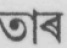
তাৰ
